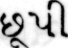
છૂપી
